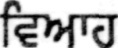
ਵਿਆਹ
